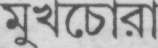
মুখচোরা
